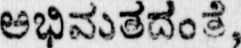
ಅಭಿಮತದಂತೆ,
